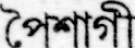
পৈশাগী
